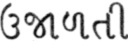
ઉજાળતી
